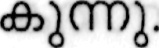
കുന്നു.
